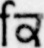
ਕਿ
